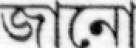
জানো
